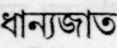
ধান্যজাত
